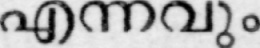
എന്നവും
